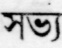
সভ্য
